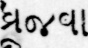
ધ્રુજવા
